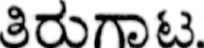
ತಿರುಗಾಟ.
